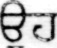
ਉਹ
